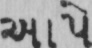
આપે
